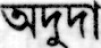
অদুদা
